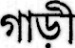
গাড়ী
